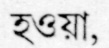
হওয়া,
